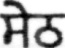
ਸੇਠ
